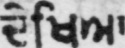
ਦੇਖਿਆ
